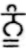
ਨੂੰ
